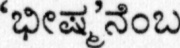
‘ಭೀಷ್ಮ’ನೆಂಬ
